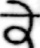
ਕੇ
